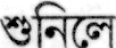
শুনিলে
